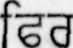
ਫਿਰ
